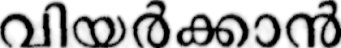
വിയര്‍ക്കാന്‍
